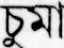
চুমা
